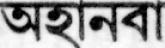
অহানবা
